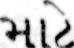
માટે
